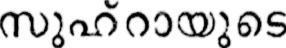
സുഹ്റായുടെ
